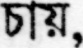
চায়,
